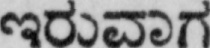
ಇರುವಾಗ
